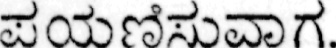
ಪಯಣಿಸುವಾಗ.
